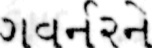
ગવર્નરને
